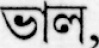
ভাল,
